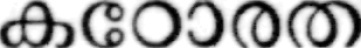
കഠോരത
